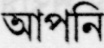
আপনি
